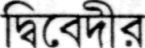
দ্বিবেদীর
